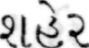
શહેર
